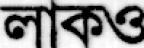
লাকও
